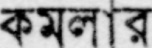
কমলার
